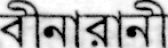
বীনারানী
